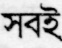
সবই
